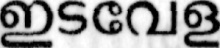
ഇടവേള
